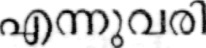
എന്നുവരി
